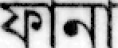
ফানা
